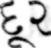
દૂર
